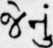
જેનું
